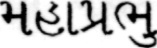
મહાપ્રભુ
